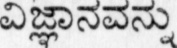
ವಿಜ್ಞಾನವನ್ನು
